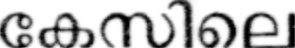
കേസിലെ
